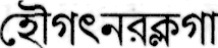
হৌগৎনরক্লগা
